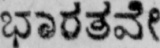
ಭಾರತವೇ
